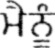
ਮੈਨੁੰ
